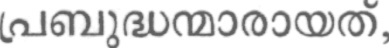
പ്രബുദ്ധന്മാരായത്,
